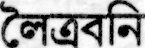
লৈত্রবনি
